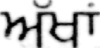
ਅੱਖਾਂ
